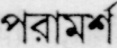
পরামর্শ
